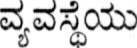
ವ್ಯವಸ್ಥೆಯು
